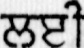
ਲਈ
